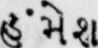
હંમેશ
